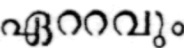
ഏററവും
